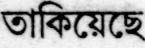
তাকিয়েছে
